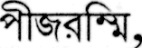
পীজরম্মি,
